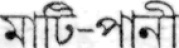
মাটি-পানী
